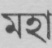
মহা
